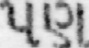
પણ
